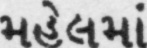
મહેલમાં
